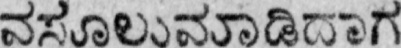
ವಸೂಲುಮಾಡಿದಾಗ
